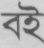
বই
